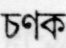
চণক
